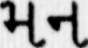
મન
